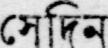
সেদিন
